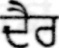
ਦੈਰ
